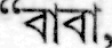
“বাবা,
